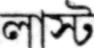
লাস্ট
